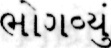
ભોગવ્યું
